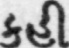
કહી
